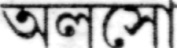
অলসো
